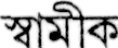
স্বামীক
